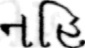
નહિ
